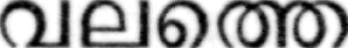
വലത്തെ
